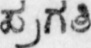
ಪ್ರಗತಿ
